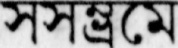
সসম্ভ্রমে
